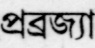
প্রব্রজ্যা
